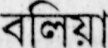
বলিয়া
